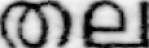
തല
